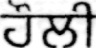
ਹੌਲੀ
